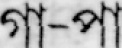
গা-পা
